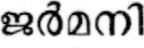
ജര്‍മനി
